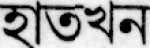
হাতখন
